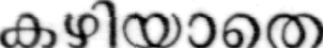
കഴിയാതെ
